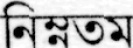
নিম্নতম
